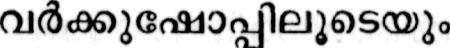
വര്‍ക്കുഷോപ്പിലൂടെയും
